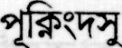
পূক্নিংদসু
